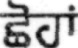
ਛੋਹਾਂ
